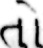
તો
